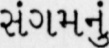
સંગમનું
